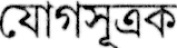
যোগসূত্রক
